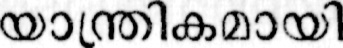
യാന്ത്രികമായി
